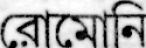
রোমোনি
